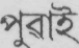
পুৱাই
